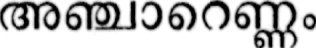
അഞ്ചാറെണ്ണം
